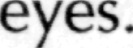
eyes.
